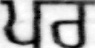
ਪਰ
